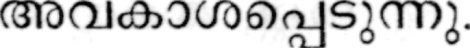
അവകാശപ്പെടുന്നു.
